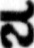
ನ
